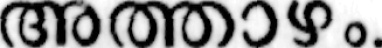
അത്താഴം.
